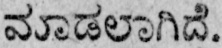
ಮಾಡಲಾಗಿದೆ.
